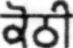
ਕੋਠੀ
